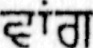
ਵਾਂਗ
